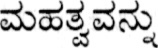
ಮಹತ್ವವನ್ನು
